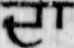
ਦਾ
